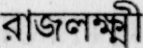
রাজলক্ষ্মী
